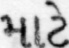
માટે
